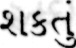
શકતું
